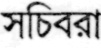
সচিবরা
